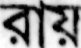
রায়
